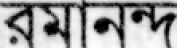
রমানন্দ
